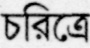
চরিত্রে
